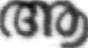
ആ
